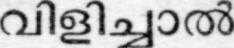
വിളിച്ചാല്‍
